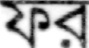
ফর
